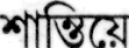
শান্তিয়ে
